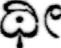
ಥೀ
